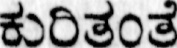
ಕುರಿತಂತೆ
